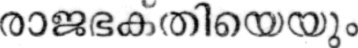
രാജഭക്തിയെയും
